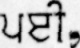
ਪਈ,
